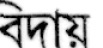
বিদায়
